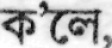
ক'লে,
